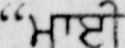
''ਮਾਈ
